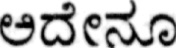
ಅದೇನೂ
